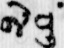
જેવું
